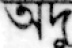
অদু
